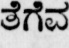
ತೆಗೆವ
